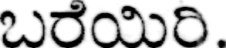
ಬರೆಯಿರಿ.
